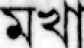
মখা
